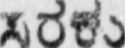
ಸರಕು
